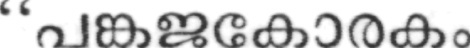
"പങ്കജകോരകം
